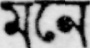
মনে
